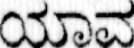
ಯಾವ
